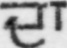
ਦਾ
